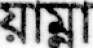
য়াম্না
